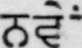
ਨਵੇਂ
